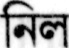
নিল
